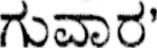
ಗುವಾರ'
